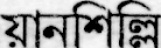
য়ানশিল্লি
